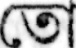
তো
